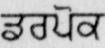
ਡਰਪੋਕ
